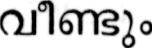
വീണ്ടും
